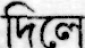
দিলে
